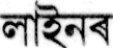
লাইনৰ
